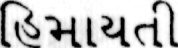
હિમાયતી
